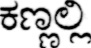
ಕಣ್ಣಲ್ಲಿ
